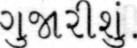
ગુજારીશું.
